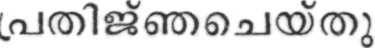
പ്രതിജ്ഞചെയ്തു
